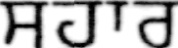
ਸਹਾਰ
